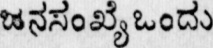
ಜನಸಂಖ್ಯೆಒಂದು
